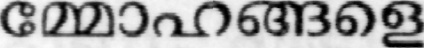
മ്മോഹങ്ങളെ
